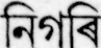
নিগৰি
